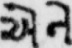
એને
